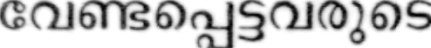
വേണ്ടപ്പെട്ടവരുടെ
